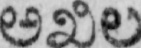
ಅಖಿಲ
